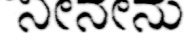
"ನೀನೇನು
